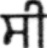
ਸੀ
